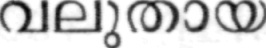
വലുതായ
